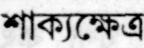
শাক্যক্ষেত্র
